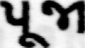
પૂજા
